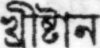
খ্রীষ্টান
